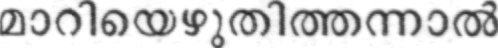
മാറിയെഴുതിത്തന്നാല്‍
